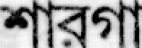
শারগা
